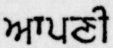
ਆਪਣੀ
